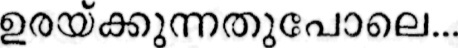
ഉരയ്ക്കുന്നതുപോലെ...
